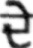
ਦੇ
